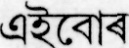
এইবোৰ
